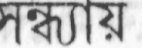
সন্ধ্যায়
